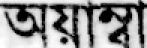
অয়াম্বা
